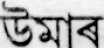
উমাৰ
